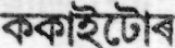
ককাইটোৰ
